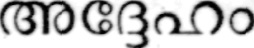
അദ്ദേഹം
